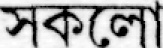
সকলো
